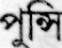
পুন্সি
